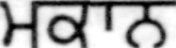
ਮਕਾਨ
